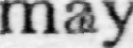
may
